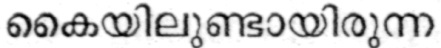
കൈയിലുണ്ടായിരുന്ന
